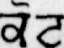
ਕੋਟ
